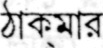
ঠাক্‌মার
